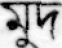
মুদ
